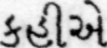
કહીએ
